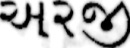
અરજી
